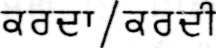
ਕਰਦਾ/ਕਰਦੀ
